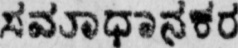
ಸಮಾಧಾನಕರ
